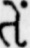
તેં
